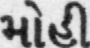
મોહી
